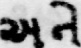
અને
